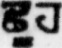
ਛੂਹ
